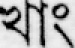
খাং
